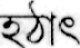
হঠাৎ
